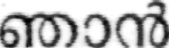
ഞാന്‍
